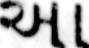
આ
